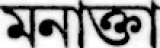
মনাক্তা
